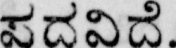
ಪದವಿದೆ.
